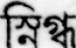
স্নিগ্ধ
